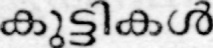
കുട്ടികള്‍
